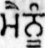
ਮੈਨੂੰ
